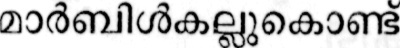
മാര്‍ബിള്‍കല്ലുകൊണ്ട്
